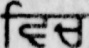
ਵਿਚ
